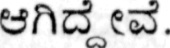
ಆಗಿದ್ದೇವೆ.
